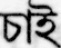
চাই
